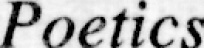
Poetics
